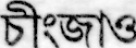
চীংজাও
